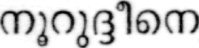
നൂറുദ്ദീനെ
